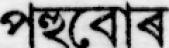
পহুবোৰ
